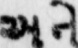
અને
